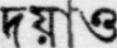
দয়াও
